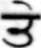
ਤੇ
